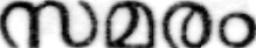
സമരം
